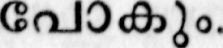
പോകും.
